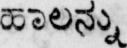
ಹಾಲನ್ನು
